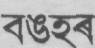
বঙহৰ
